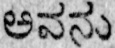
ಅವನು
